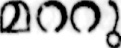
മററു
